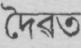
দৈৱত
